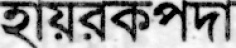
হায়রকপদা
